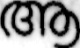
ആ
